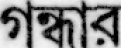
গন্ধার
